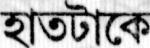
হাতটাকে
